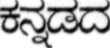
ಕನ್ನಡದ
